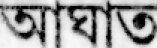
আঘাত
